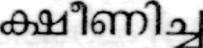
ക്ഷീണിച്ച
